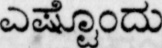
ಎಷ್ಟೊಂದು
